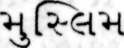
મુસ્લિમ
